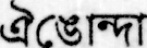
ঐঙোন্দা
